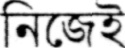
নিজেই
